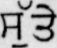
ਸੁੱਤੇ
